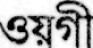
ওয়গী
